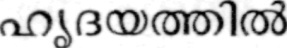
ഹൃദയത്തില്‍
